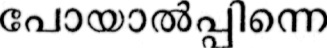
പോയാല്‍പ്പിന്നെ
